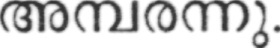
അമ്പരന്നു.
